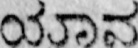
ಯಾವ
